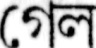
গেল
